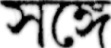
সঙ্গে
